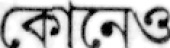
কোনেও
